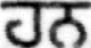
ਹਨ
